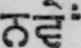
ਨਵੇਂ
